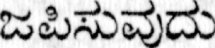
ಜಪಿಸುವುದು
